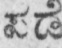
ಪಡೆ
